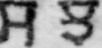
ਸਝ
